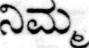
ನಿಮ್ಮ
